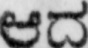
ಆದ
